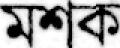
মশক
